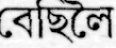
বেছিলৈ
